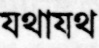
যথাযথ
